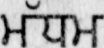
ਮੱਧਮ
